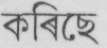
কৰিছে
